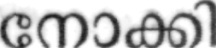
നോക്കി
